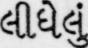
લીધેલુ
